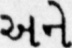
અને
